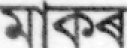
মাকৰ
